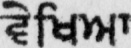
ਵੇਖਿਆ
